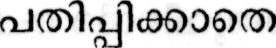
പതിപ്പിക്കാതെ
